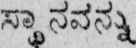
ಸ್ಥಾನವನ್ನು
